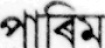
পাৰিম
